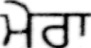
ਮੇਰਾ
